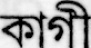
কাগী
